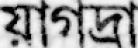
য়াগদ্রা
